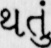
થતું
